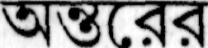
অন্তরের
